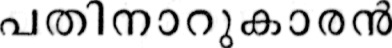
പതിനാറുകാരന്‍
